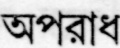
অপরাধ
